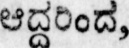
ಆದ್ದರಿಂದ,
